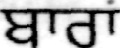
ਬਾਰਾਂ
